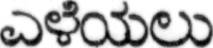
ಎಳೆಯಲು
